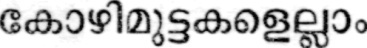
കോഴിമുട്ടകളെല്ലാം
